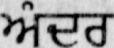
ਅੰਦਰ
